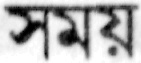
সময়
